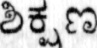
ಶಿಕ್ಷಣ
